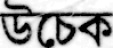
উচেক
